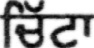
ਚਿੱਟਾ
